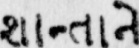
શાન્તાને
